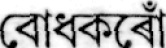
বোধকৰোঁ
